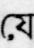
যে
